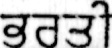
ਭਰਤੀ
